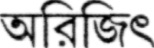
অরিজিৎ
